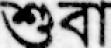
শুবা
